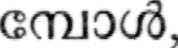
മ്പോള്‍,
